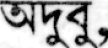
অদুবু,
